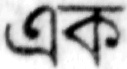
এক
